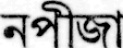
নপীজা
